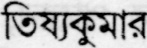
তিষ্যকুমার
